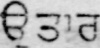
ਉਤਾਰ
